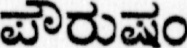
ಪೌರುಷ೦
